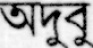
অদুবু
